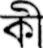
কী
